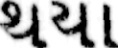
થયા
